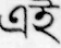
এই
